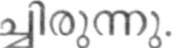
ച്ചിരുന്നു.
